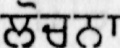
ਲੋਚਨਾ
